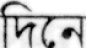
দিনে
